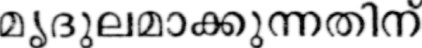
മൃദുലമാക്കുന്നതിന്
